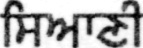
ਸਿਆਣੀ
